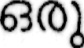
ഒരു
